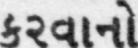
કરવાનો
